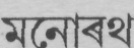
মনোৰথ
